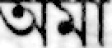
অমা
